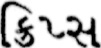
ક્રિપ્સ
